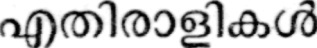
എതിരാളികള്‍
